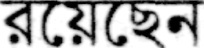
রয়েছেন
